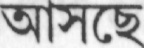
আসছে
